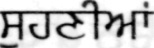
ਸੁਹਣੀਆਂ
